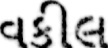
વકીલ
